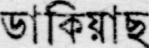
ডাকিয়াছ
